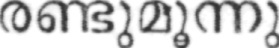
രണ്ടുമൂന്നു
